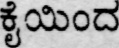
ಕೈಯಿ೦ದ
